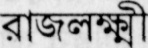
রাজলক্ষ্মী
